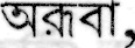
অরূবা,
